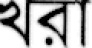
খরা
